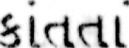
કાંતતા
